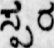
ಸ್ಪರ
